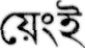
য়েংই
